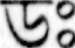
ডঃ
